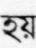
হয়
